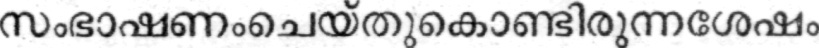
സഭാഷണംചെയതുകൊണ്ടരുന്നശേഷം
